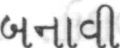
બનાવી
